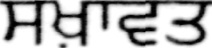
ਸਖ਼ਾਵਤ
